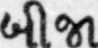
બીજા
